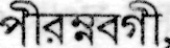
পীরম্নবগী,
